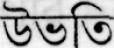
উভতি
